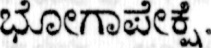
ಭೋಗಾಪೇಕ್ಷೆ.
